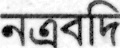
নত্ত্রবদি
